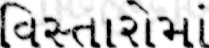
વિસ્તારોમાં
